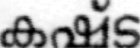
കഷ്ട
